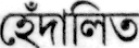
হেঁদালিত
